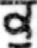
ਕੁ
